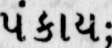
પંકાય;
